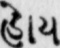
હોય
